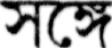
সঙ্গে
